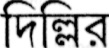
দিল্লির
